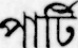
পাৰ্টি
